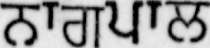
ਨਾਗਪਾਲ
